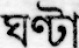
ঘণ্টা
